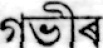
গভীৰ
